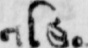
નહિ.
